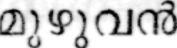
മുഴുവന്‍
